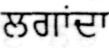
ਲਗਾਂਦਾ
